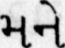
મને
